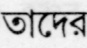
তাদের
